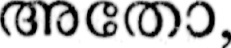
അതോ,
